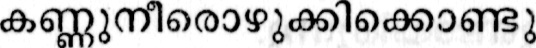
കണ്ണുനീരൊഴുക്കികൊണ്ടു
